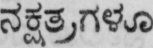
ನಕ್ಷತ್ರಗಳೂ
